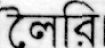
লৈরি।
